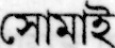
সোমাই
